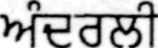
ਅੰਦਰਲੀ
